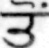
ਤੋਂ
